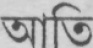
আতি
